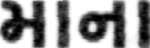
માના
